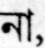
না,
